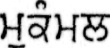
ਮੁਕੰਮਲ
